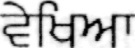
ਵੇਖਿਆ
